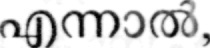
എന്നാല്‍,
